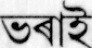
ভৰাই
